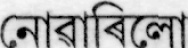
নোৱাৰিলো
